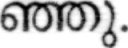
ഞ്ഞു.
